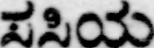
ಸಸಿಯ
